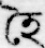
হৈ
